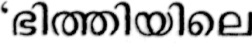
‘ഭിത്തിയിലെ
